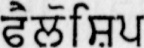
ਫੈਲੋਸ਼ਿਪ
